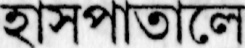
হাসপাতালে
